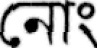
নোং
